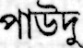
পাউদু
